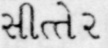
સીત્તેર
